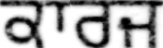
ਕਾਰਜ
